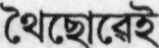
থৈছোৱেই
